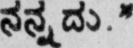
ನನ್ನದು.”
